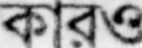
কারও
